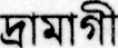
দ্রামাগী
